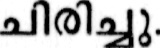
ചിരിച്ചു.
